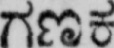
ಗಣಕ
